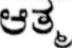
ಆತ್ಮ
